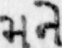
મને
